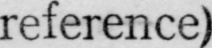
reference)
